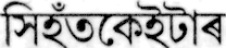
সিহঁতকেইটাৰ
